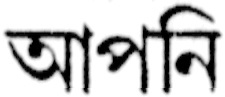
আপনি
